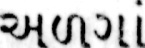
અળગાં
